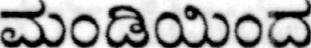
ಮಂಡಿಯಿಂದ
